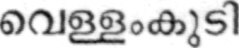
വെള്ളംകുടി
